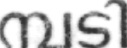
മ്പടി:
